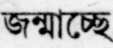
জন্মাচ্ছে
